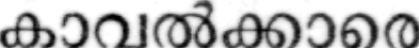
കാവല്‍ക്കാരെ
